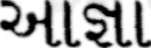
આજ્ઞા
